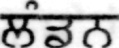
ਲੰਡਨ
